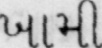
ખામી
